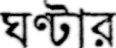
ঘণ্টার
